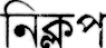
নিক্লপ
